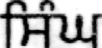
ਸਿੰਘ
